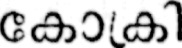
കോക്രി
